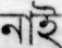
নাই
